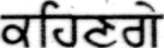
ਕਹਿਣਗੇ
